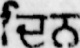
ਦਿਨ
